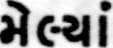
મેલ્યાં
